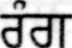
ਰੰਗ
